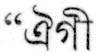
“ঐগী
